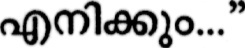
എനിക്കും…”
